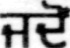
ਜਦੋਂ
